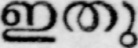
ഇതു
